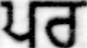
ਪਰ
